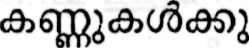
കണ്ണുകള്‍ക്കു
